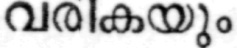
വരികയും
